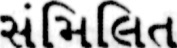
સંમિલિત
